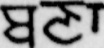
ਬਣਾ
